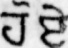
ਹੋਏ
